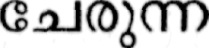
ചേരുന്ന
